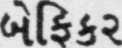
બેફિકર
